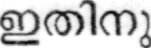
ഇതിനു
